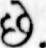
છે.
